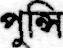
পুন্সি
